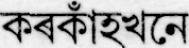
কৰকাঁহখনে
